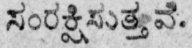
ಸಂರಕ್ಷಿಸುತ್ತವೆ.
